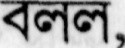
বলল,
